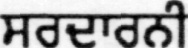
ਸਰਦਾਰਨੀ
